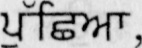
ਪੁੱਛਿਆ,
